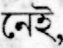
নেই,
